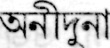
অনীদুনা
